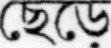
ছেড়ে
